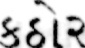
કઠોર
